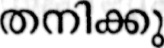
തനിക്കു
